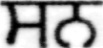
ਸਨ
